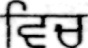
ਵਿਚ
